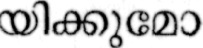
യിക്കുമോ
